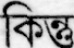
কিন্তু
